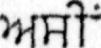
ਅਸੀਂ
